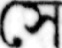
সে
